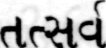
તત્સર્વ
